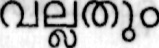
വല്ലതും
